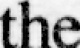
the
